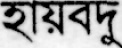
হায়বদু
